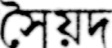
সৈয়দ
